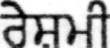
ਰੇਸ਼ਮੀ
